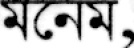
মনেম,
